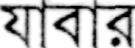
যাবার
